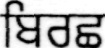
ਬਿਰਛ
